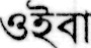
ওইকবা
